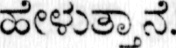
ಹೇಳುತ್ತಾನೆ.
